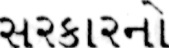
સરકારનો
